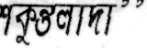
শকুন্তলাদা”
